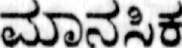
ಮಾನಸಿಕ
